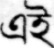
এই
